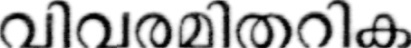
വിവരമിതറിക
